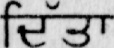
ਦਿੱਤਾ
